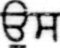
ਉਸ
